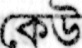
কেউ
